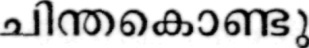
ചിന്തകൊണ്ടു
